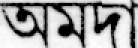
অমদা
